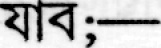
যাব;-
